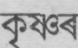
কৃষ্ণৰ
